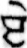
ਏ
